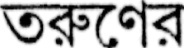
তরুণের
